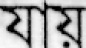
যায়
